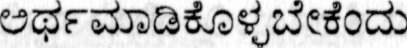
ಅರ್ಥಮಾಡಿಕೊಳ್ಳಬೇಕೆಂದು
